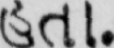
હતા.
